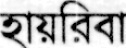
হায়রিবা
